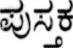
ಪುಸ್ತಕ
